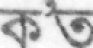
ক'ত
